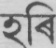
হৰি
